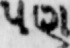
પણ
